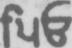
ਪਿਓ
